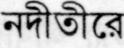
নদীতীরে
